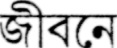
জীবনে
